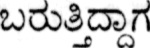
ಬರುತ್ತಿದ್ದಾಗ
